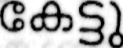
കേട്ടു
